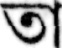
তা
